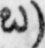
ಬ)
